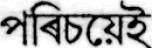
পৰিচয়েই
